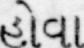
હોવા
